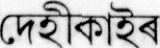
দেহীকাইৰ
